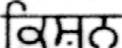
ਕਿਸ਼ਨ
